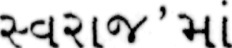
સ્વરાજ'માં
